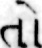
તો
